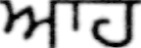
ਆਹ
